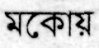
মকোয়
